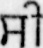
ਸੀ
